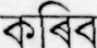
কৰিব
